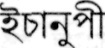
ইচানুপী
